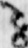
કે
